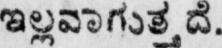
ಇಲ್ಲವಾಗುತ್ತದೆ.
